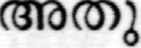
അതു
